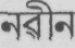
নৱীন
